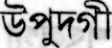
উপুদগী
